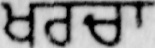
ਖਰਚਾ
